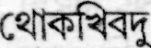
থোকখিবদু
